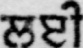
ਲਈ
